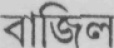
বাজিল
